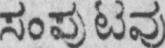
ಸಂಪುಟವು
